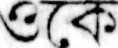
ওকে
